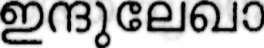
ഇന്ദുലേഖാ
